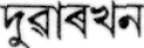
দুৱাৰখন
